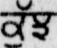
ਕੁੱਝ
